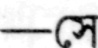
–সে
